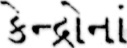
કેન્દ્રોમાં
